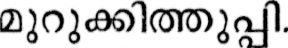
മുറുക്കിത്തുപ്പി.
